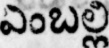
ಎಂಬಲ್ಲಿ
